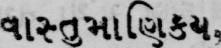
વાસ્તુમાણિક્ય,
